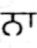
ਨਾ
